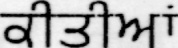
ਕੀਤੀਆਂ
